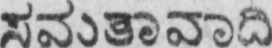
ಸಮತಾವಾದಿ
